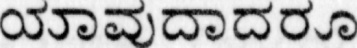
ಯಾವುದಾದರೂ
